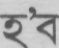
হ'ব
